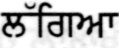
ਲੱਗਿਆ
